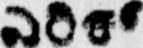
ಎರಿಕ್
